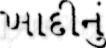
ખાદીનું
